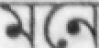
মনে
